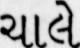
ચાલે
